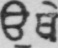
ਉਥੇ
